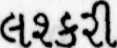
લશ્કરી
